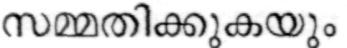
സമ്മതിക്കുകയും
